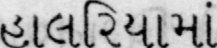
હાલરિયામાં
